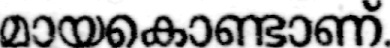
മായകൊണ്ടാണ്.
